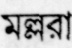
মল্লরা
